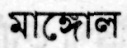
মাঙ্গোল
